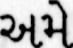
અમે
